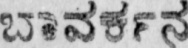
ಬಾವರ್ಕನ
